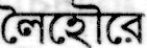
লৈহৌরে
